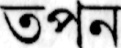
তপন
